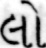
લો
